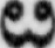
ೞ
